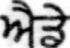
ਐਡੇ
